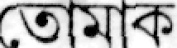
তোমাক
